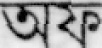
অফ
